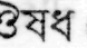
ঔষধ
